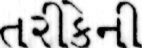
તરીકેની
